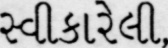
સ્વીકારેલી,
